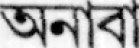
অনাবা
